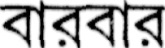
বারবার
